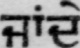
ਜਾਂਦੇ
